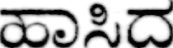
ಹಾಸಿದ
